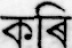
কৰি
